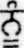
ਨੂੰ
